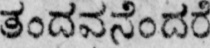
ತಂದವನೆಂದರೆ
